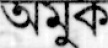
অমুক
